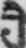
ਹੈ
